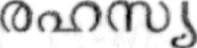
രഹസ്യ
